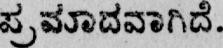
ಪ್ರಮಾದವಾಗಿದೆ.
